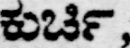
ಕುರ್ಚಿ,
